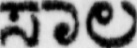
ಸಾಲ
